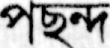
পছন্দ
